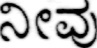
ನೀವು
